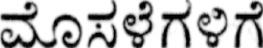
ಮೊಸಳೆಗಳಿಗೆ
